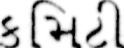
કમિટી
